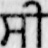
ਸੀ
